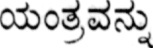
ಯಂತ್ರವನ್ನು
